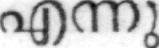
എന്നു
